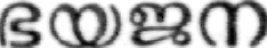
ഭയജന
